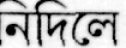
নিদিলে
